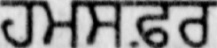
ਹਮਸਫ਼ਰ
